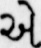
એ
